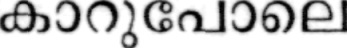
കാറുപോലെ
